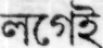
লগেই
